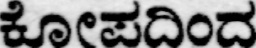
ಕೋಪದಿಂದ
